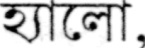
হ্যালো,
